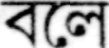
বলে
